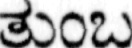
ತುಂಬ
